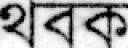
থবক
